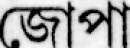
জোপা
